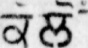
ਕੋਲੋ
